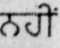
ਨਹੀਂ
